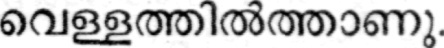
വെള്ളത്തില്‍ത്താണു.
